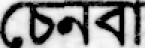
চেনবা
